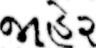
જાહેર
